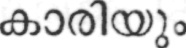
കാരിയും
